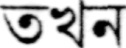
তখন
